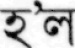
হ'ল
